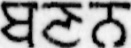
ਬਣਨ
